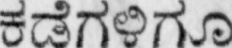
ಕಡೆಗಳಿಗೂ
